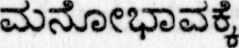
ಮನೋಭಾವಕ್ಕೆ
